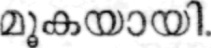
മൂകയായി.
